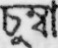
চুম্বা
